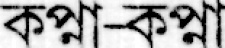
কপ্না-কপ্না
